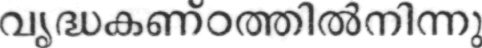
വൃദ്ധകണ്ഠത്തില്‍നിന്നു
